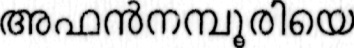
അഫന്‍നമ്പൂരിയെ
